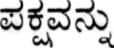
ಪಕ್ಷವನ್ನು
